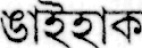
ঙাইহাক
